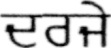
ਦਰਜੇ
